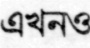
এখনও
